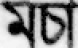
মচা
